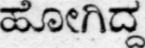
ಹೋಗಿದ್ದ
